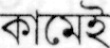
কামেই
